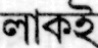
লাকই
